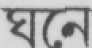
ঘনে
